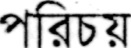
পরিচয়
